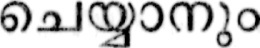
ചെയ്യാനും
